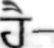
ਹੈ-
